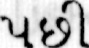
પછી
